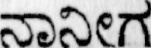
ನಾನೀಗ
